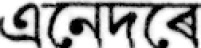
এনেদৰে
